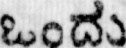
ಒಂದು
